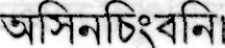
অসিনচিংবনি।
